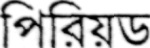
পিরিয়ড
